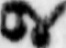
જ
